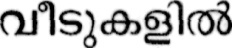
വീടുകളില്‍
